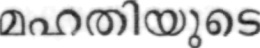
മഹതിയുടെ
